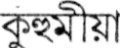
কুহুমীয়া
